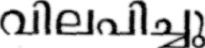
വിലപിച്ചു
